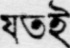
যতই
